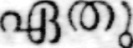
ഏതു
